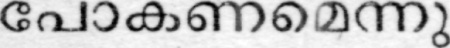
പോകണമെന്നു
